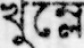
খুম্লে
